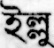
ইল্লু
